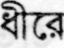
ধীরে
